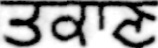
ਤਕਾਣ
